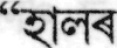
"হালৰ
